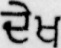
ਦੇਖ
